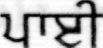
ਪਾਈ
